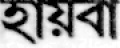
হায়বা
